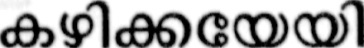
കഴിക്കയേയി
